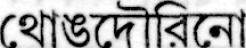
থোঙদৌরিবনো
